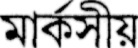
মার্কসীয়
